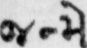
જન્મે
